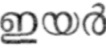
ഇയര്‍
